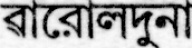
ৱারোলদুনা
